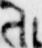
તો
